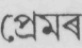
প্রেমৰ
